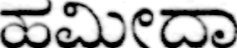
ಹಮೀದಾ
